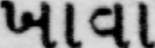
ખાવા
